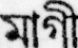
মাগী
